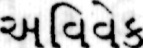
અવિવેક
